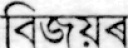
বিজয়ৰ
